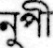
নুপী
